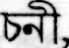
চনী,
